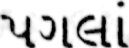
પગલાં
